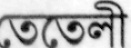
তেতেলী
